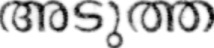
അടുത്ത
